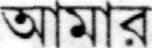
আমার
